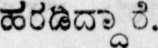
ಹರಡಿದ್ದಾರೆ.
